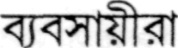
ব্যবসায়ীরা
